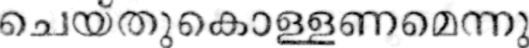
ചെയ്തുകൊള്ളണമെന്നു
